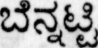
ಬೆನ್ನಟ್ಟಿ
